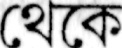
থেকে
